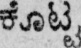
ಕೊಟ್ಟ
